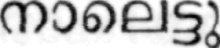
നാലെട്ടു
